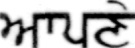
ਆਪਣੇ
